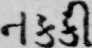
નક્કી
